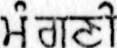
ਮੰਗਣੀ
